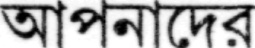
আপনাদের
